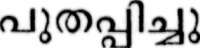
പുതപ്പിച്ചു
